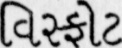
વિસ્ફોટ
